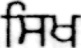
ਸਿਖ
